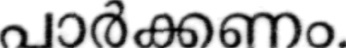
പാര്‍ക്കണം.
